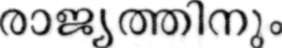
രാജ്യത്തിനും
